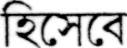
হিসেবে
